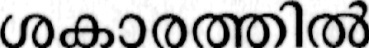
ശകാരത്തില്‍
